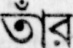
তাঁর
